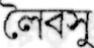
লৈবসু
